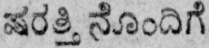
ಷರತ್ತಿನೊಂದಿಗೆ
